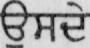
ਉਸਦੇ
